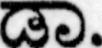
ಡಾ.
